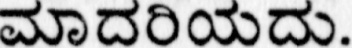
ಮಾದರಿಯದು.
